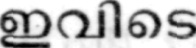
ഇവിടെ
